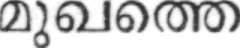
മുഖത്തെ
